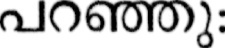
പറഞ്ഞു:
